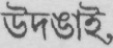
উদঙাই,
